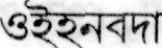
ওইহনবদা
